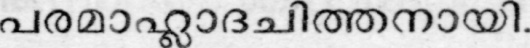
പരമാഹ്ളാദചിത്തനായി.
